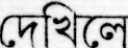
দেখিলে
